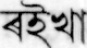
ৰইখা
